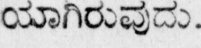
ಯಾಗಿರುವುದು.
